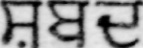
ਸ਼ਬਦ
